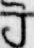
ਹੋ
